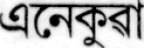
এনেকুৱা
